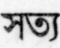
সত্য
